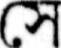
সে
